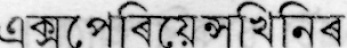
এক্সপেৰিয়েন্সখিনিৰ
